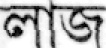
লাজ
